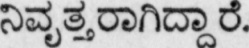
ನಿವೃತ್ತರಾಗಿದ್ದಾರೆ.
